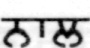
ਨਾਲ
